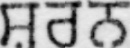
ਸ਼ਰਨ
